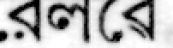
রেলৱে
